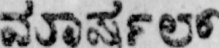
ಮಾರ್ಷಲ್
